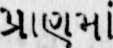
પ્રાણમાં
